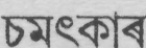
চমৎকাৰ
